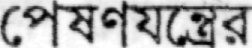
পেষণযন্ত্রের
